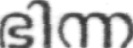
ഭിന്ന
